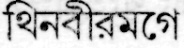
থিনবীরমগে
